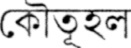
কৌতূহল
